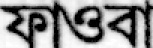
ফাওবা
